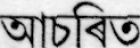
আচৰিত
